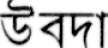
উবদা
